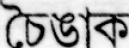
চৈঙাক
